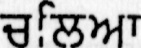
ਚਲਿਆ
